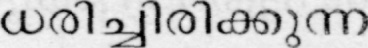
ധരിച്ചിരിക്കുന്ന
